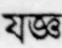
যজ্ঞ
